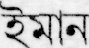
ইমান
